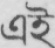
এই
